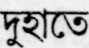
দুহাতে
